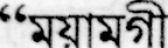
“ময়ামগী
